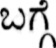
ಬಗ್ಗೆ
